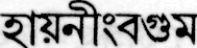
হায়নীংবগুম
